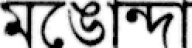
মঙোন্দা
